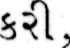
કરી,
